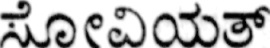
ಸೋವಿಯತ್
